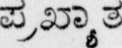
ಪ್ರಖ್ಯಾತ
